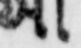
આ
